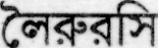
লৈরুরসি
